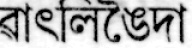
ৱাৎলিঙৈদা
